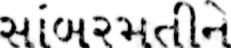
સાંબરમતીને
